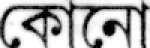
কোনো
